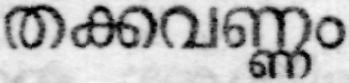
തക്കവണ്ണം
